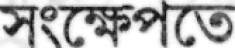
সংক্ষেপতে
